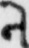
ને
